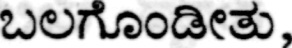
ಬಲಗೊಂಡೀತು,
